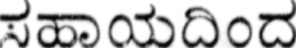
ಸಹಾಯದಿಂದ
